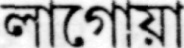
লাগোয়া
